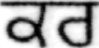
ਕਰ
